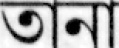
তানা
